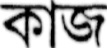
কাজ
